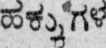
ಹಕ್ಕುಗಳ
